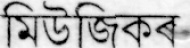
মিউজিকৰ
